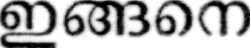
ഇങ്ങനെ
